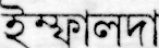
ইম্ফালদা
